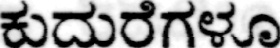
ಕುದುರೆಗಳೂ
